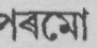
পৰমো
